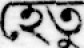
হেতু
